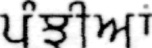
ਪੰਝੀਆਂ
